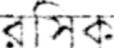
রসিক
